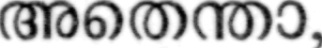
അതെന്താ,
